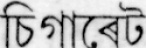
চিগাৰেট
